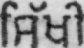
ਸਿੱਖੀ
